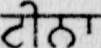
ਟੀਨਾ
